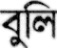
বুলি
